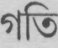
গতি
